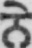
ਨੇ
